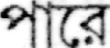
পারে
